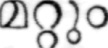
മറ്റും
